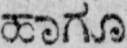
ಹಾಗೂ
